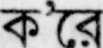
ক'রে
